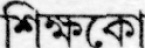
শিক্ষকো
